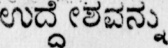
ಉದ್ದೇಶವನ್ನು
